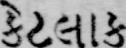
કેટલાક
